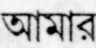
আমার
